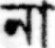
না
